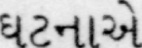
ઘટનાએ
